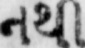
નથી
